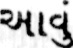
આવું
